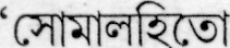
'সোমালহিতো
